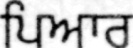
ਪਿਆਰ
